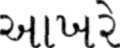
આખરે
